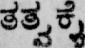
ತತ್ವಕ್ಕೆ
